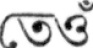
তেওঁ
